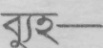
ব্যুহ-
